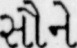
સૌને
